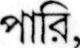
পারি,
